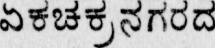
ಏಕಚಕ್ರನಗರದ
